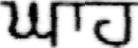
ਘਾਹ
